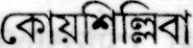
কোয়শিল্লিবা
